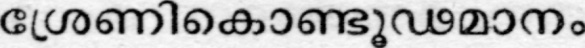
ശ്രേണികൊണ്ടൂഢമാനം
